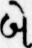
બે
